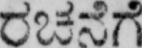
ರಚನೆಗೆ
